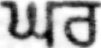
ਘਰ
